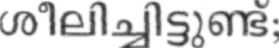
ശീലിച്ചിട്ടുണ്ട്;
